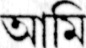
আমি
